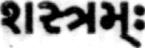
શસ્ત્રમ્:
